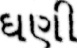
ઘણી
